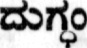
ದುಗ್ಧಂ
